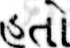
હતો
